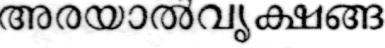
അരയാല്‍വൃക്ഷങ്ങ
